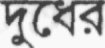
দুধের
